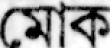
মোক
